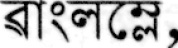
ৱাংলম্লে,
